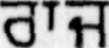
ਰਾਜ
